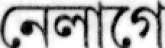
নেলাগে
